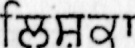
ਲਿਸ਼ਕਾ
